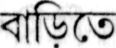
বাড়িতে
